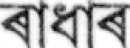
ৰাধাৰ
